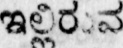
ಇಲ್ಲಿರುವ
